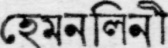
হেমনলিনী
